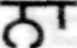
ਨਾ
